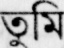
তুমি
